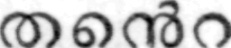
തന്റെ
